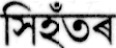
সিহঁতৰ
